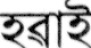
হৱাই
